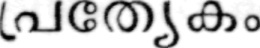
പ്രത്യേകം
